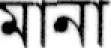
মানা
